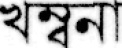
খম্বনা
